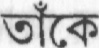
তাঁকে
